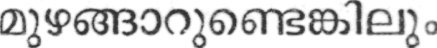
മുഴങ്ങാറുണ്ടെങ്കിലും
